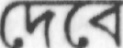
দেবে
